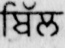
ਬਿੱਲ
